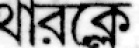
থারক্লে
